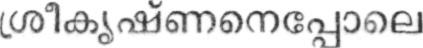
ശ്രീകൃഷ്ണനെപ്പോലെ
